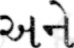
અને
